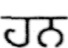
ਹਨ
